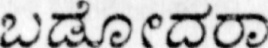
ಬಡೋದರಾ
